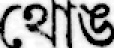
থোঙ
